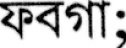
ফবগা;
